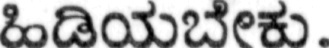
ಹಿಡಿಯಬೇಕು.
